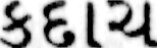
કદાચ
